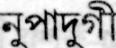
নুপাদুগী
